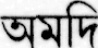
অমদি
